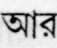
আর
